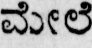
ಮೇಲೆ
